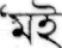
'মই
